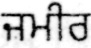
ਜਮੀਰ
